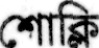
শোক্লি
